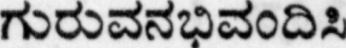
ಗುರುವನಭಿವಂದಿಸಿ
